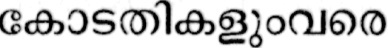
കോടതികളുംവരെ
